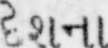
દેશના
